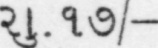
રા.૧૭/-
